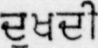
ਦੁਖਦੀ
